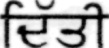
ਦਿੱਤੀ
